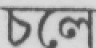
চলে
